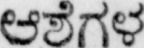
ಆಶೆಗಳ
